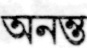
অনন্ত
